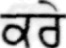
ਕਰੇ
